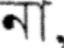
না,
